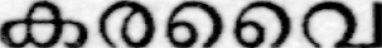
കരവൈ
